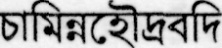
চামিন্নহৌদ্রবদি
